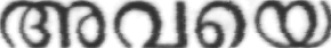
അവയെ
